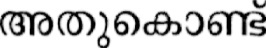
അതുകൊണ്ട്
